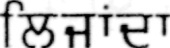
ਲਿਜਾਂਦਾ
